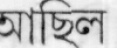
আছিল
